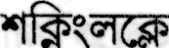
শক্নিংলক্লে
